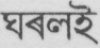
ঘৰলই
